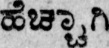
ಹೆಚ್ಚಾಗಿ
